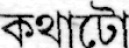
কথাটো
